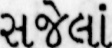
સજેલાં
